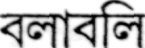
বলাবলি
